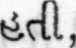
હતી,
